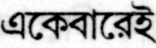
একেবারেই
